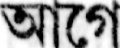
আগে
